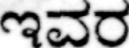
ಇವರ
